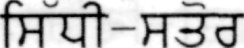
ਸਿੱਧੀ-ਸਤੋਰ
